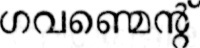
ഗവണ്മെന്റ്
